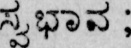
ಸ್ವಭಾವ;
